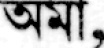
অমা,
